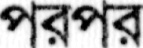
পরপর
